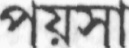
পয়সা
